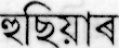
হুছিয়াৰ
